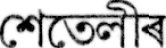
শেতেলীৰ
